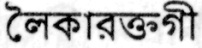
লৈকারক্তগী
